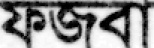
ফজবা
